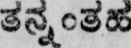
ತನ್ನಂತಹ
